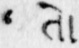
'તો
